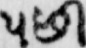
પછી
